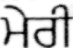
ਮੇਰੀ
